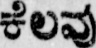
ಕೆಲವು
